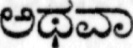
ಅಥವಾ
